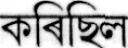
কৰিছিল
